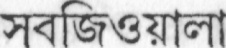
সবজিওয়ালা
